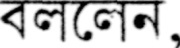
বললেন,
